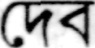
দেব
